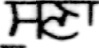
ਸੁਣਾ
